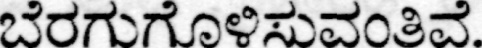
ಬೆರಗುಗೊಳಿಸುವಂತಿವೆ.
